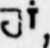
ਹਾਂ,
